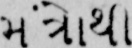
મંત્રોથી
